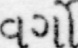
વર્ગો
